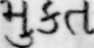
મુકત
